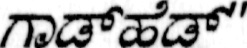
ಗಾಡ್‌ಹೆಡ್”
